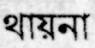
থায়না
